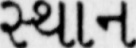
સ્થાન
